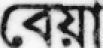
বেয়া
